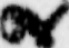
જ
